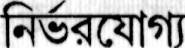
নির্ভরযোগ্য
